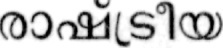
രാഷ്ട്രീയ
